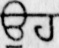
ਉਹ
